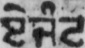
ਏਜੰਟ
